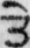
ਤੇ
